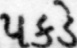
પકડે
